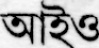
আইও
